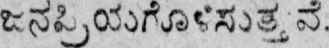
ಜನಪ್ರಿಯಗೊಳಿಸುತ್ತವೆ.
